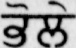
ਭੋਲੇ
